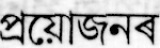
প্ৰয়োজনৰ
